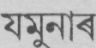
যমুনাৰ
